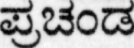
ಪ್ರಚಂಡ
